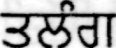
ਤਲੰਗ
